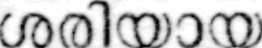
ശരിയായ
